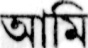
আমি
